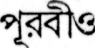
পূরবীও
